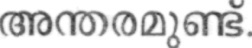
അന്തരമുണ്ട്.
